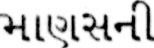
માણસની
